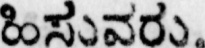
ಹಿಸುವರು.
